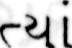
ત્યાં
